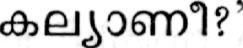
കല്യാണീ?’
